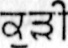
ਕੁੜੀ
